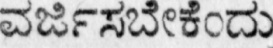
ವರ್ಜಿಸಬೇಕೆಂದು
